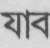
যাব
